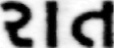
રાત
